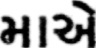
માએ
